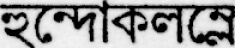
হুন্দোকলম্লে
